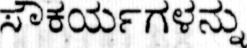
ಸೌಕರ್ಯಗಳನ್ನು
